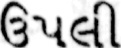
ઉપલી
